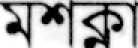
মশক্না
